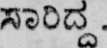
ಸಾರಿದ್ದ.
